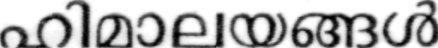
ഹിമാലയങ്ങള്‍
